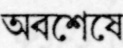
অবশেষে
